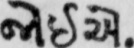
જોઈએ.
